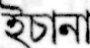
ইচানা
